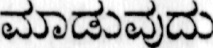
ಮಾಡುವುದು
